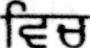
ਵਿਚ
